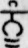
ਨੂੰ
